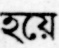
হয়ে
